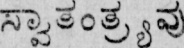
ಸ್ವಾತಂತ್ರ್ಯವು
